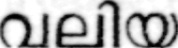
വലിയ
